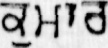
ਕੁਮਾਰ
